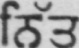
ਨਿੱਤ
